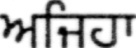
ਅਜਿਹਾ
